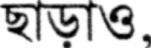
ছাড়াও,
